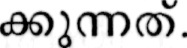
ക്കുന്നത്.
